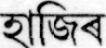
হাজিৰ
